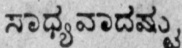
ಸಾಧ್ಯವಾದಷ್ಟು
